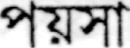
পয়সা
